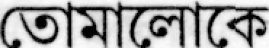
তোমালোকে
